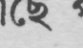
পাছে
